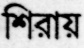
শিরায়
